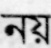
নয়
